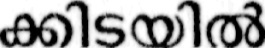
ക്കിടയില്‍
